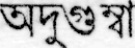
অদুগুম্বা
